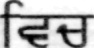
ਵਿਚ
